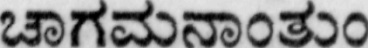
ಚಾಗಮನಾಂತುಂ
